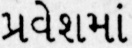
પ્રવેશમાં
